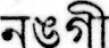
নঙগী
